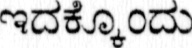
ಇದಕ್ಕೊಂದು
